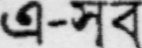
এ-সব
